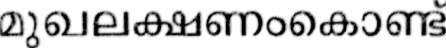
മുഖലക്ഷണംകൊണ്ട്
